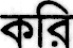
করি
